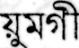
য়ুমগী
